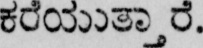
ಕರೆಯುತ್ತಾರೆ.
